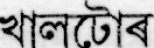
খালটোৰ
